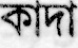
কাদা
